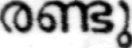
രണ്ടു
